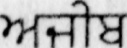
ਅਜੀਬ
